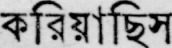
করিয়াছিস
